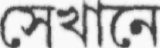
সেখানে
